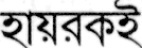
হায়রকই
